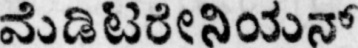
ಮೆಡಿಟರೇನಿಯನ್
